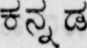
ಕನ್ನಡ
